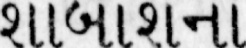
શાબાશના
